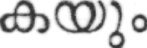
കയും
